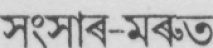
সংসাৰ-মৰুত
